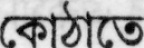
কোঠাতে
